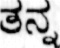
ತನ್ನ
